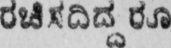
ರಚಿಸದಿದ್ದರೂ
